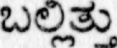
ಬಲ್ಲಿತ್ತು
